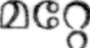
മറ്റേ
